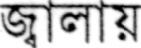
জ্বালায়
